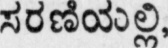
ಸರಣಿಯಲ್ಲಿ,
